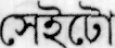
সেইটো
